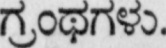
ಗ್ರಂಥಗಳು.
